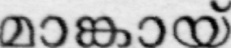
മാങ്കായ്
